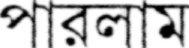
পারলাম
